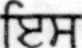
ਇਸ
